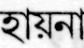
হায়না
